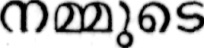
നമ്മുടെ
